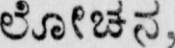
ಲೋಚನ,
